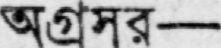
অগ্রসর—
